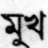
মুখ
